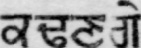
ਕਢਣਗੇ
